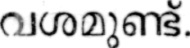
വശമുണ്ട്.
